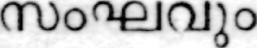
സംഘവും
